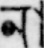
না
